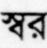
স্বর
